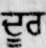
ਦੂਰ
